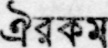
ঐরকম
